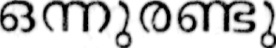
ഒന്നുരണ്ടു
